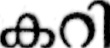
കറി
